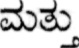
ಮತ್ತು
